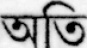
অতি
